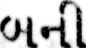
બની
